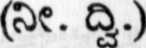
(ನೀ.ದ್ವಿ.)
